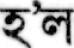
হ'ল
